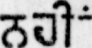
ਨਹੀਂ
